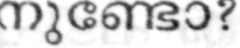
നുണ്ടോ?
